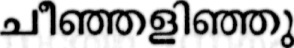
ചീഞ്ഞളിഞ്ഞു
